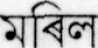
মৰিল
